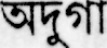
অদুগা
